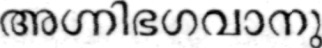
അഗ്നിഭഗവാനു
